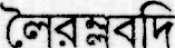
লৈরম্লবদি
